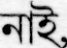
নাই,
